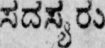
ಸದಸ್ಯರು
